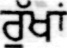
ਰੁੱਖਾਂ
